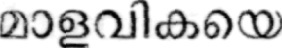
മാളവികയെ
